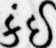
કંઈ
